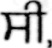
ਸੀ,
